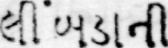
લીંબડાની
